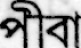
পীবা
